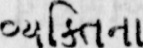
વ્યક્તિના
